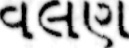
વલણ
